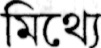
মিথ্যে
